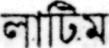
লাটিম
